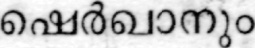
ഷെര്‍ഖാനും
